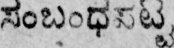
ಸಂಬಂಧಪಟ್ಟ
